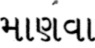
માણવા
